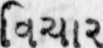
વિચાર
